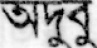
অদুবু
